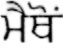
ਮੈਥੋਂ
